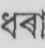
ধৰা
